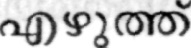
എഴുത്ത്
